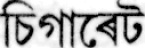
চিগাৰেট
